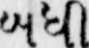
બધી
